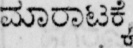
ಮಾರಾಟಕ್ಕೆ
